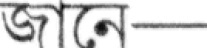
জানে-
